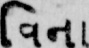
વિના
